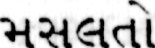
મસલતો
